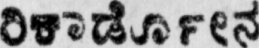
ರಿಕಾರ್ಡೋನ
